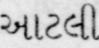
આટલી
